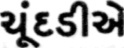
ચૂંદડીએ
